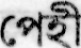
পেহী
